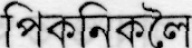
পিকনিকলৈ
